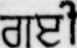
ਗਈ
